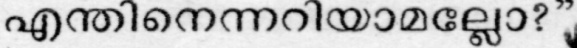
എന്തിനെന്നറിയാമല്ലോ?"
